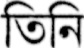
তিনি
